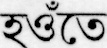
হওঁতে
